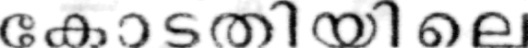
കോടതിയിലെ
